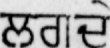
ਲਗਦੇ
